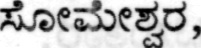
ಸೋಮೇಶ್ವರ,
